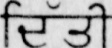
ਦਿੱਤੀ
